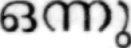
ഒന്നു
